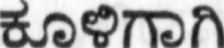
ಕೂಳಿಗಾಗಿ
